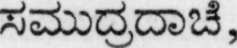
ಸಮುದ್ರದಾಚೆ,
